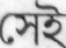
সেই
